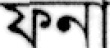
ফনা
